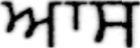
ਆਸ
